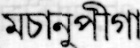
মচানুপীগা
